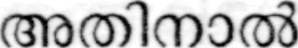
അതിനാല്‍
